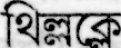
থিল্লক্লে
